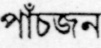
পাঁচজন
